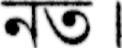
নত।
